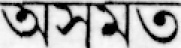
অসমত
